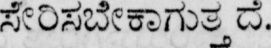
ಸೇರಿಸಬೇಕಾಗುತ್ತದೆ.
